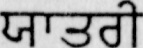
ਯਾਤਰੀ
